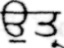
ਉਤ੍ਰ
